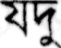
যদু
